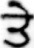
ਤੇ
